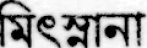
মিৎস্নানা
